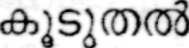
കൂടുതല്‍
